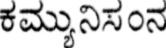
ಕಮ್ಯುನಿಸಂನ
